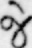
જે
